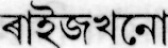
ৰাইজখনো
